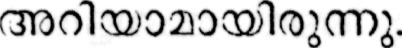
അറിയാമായിരുന്നു.
